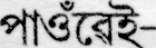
পাওঁৱেই-
